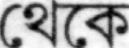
থেকে
